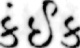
કંઇક
